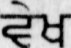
ਵੇਖ
